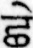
ਛੇ
